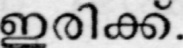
ഇരിക്ക്.
